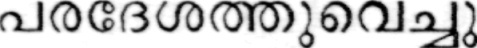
പരദേശത്തുവെച്ചു
